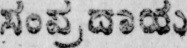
ಸಂಪ್ರದಾಯ
